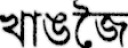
খাঙজৈ
